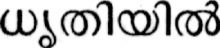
ധൃതിയില്‍
